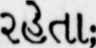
રહેતા;
